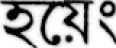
হয়েং
